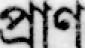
প্রাণ
